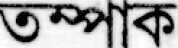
তম্পাক
